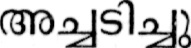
അച്ചടിച്ചു
